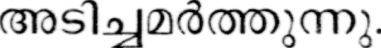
അടിച്ചമര്‍ത്തുന്നു.
